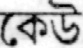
কেউ
